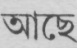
আছে
